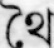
থৈ
